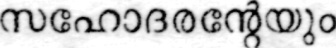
സഹോദരന്റേയും
